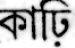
কাঢ়ি
